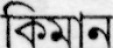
কিমান
